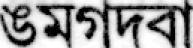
ঙমগদবা
